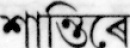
শান্তিৰে
